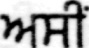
ਅਸੀਂ
